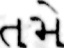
તમે
